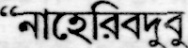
“নাহেরিবদুবু
